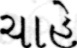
ચાહે
